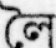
লৈ
